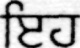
ਇਹ
